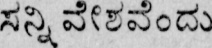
ಸನ್ನಿವೇಶವೆಂದು
